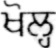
ਖੋਲ੍ਹ
